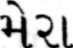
મેરા
